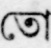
তো
